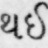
થઈ
